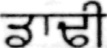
ਡਾਢੀ
